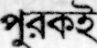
পুরকই
